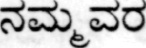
ನಮ್ಮವರ
